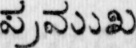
ಪ್ರಮುಖ
